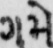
ગમે
